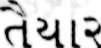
તૈયાર
